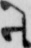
ને
